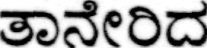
ತಾನೇರಿದ
